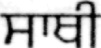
ਸਾਥੀ
